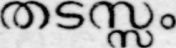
തടസ്സം
